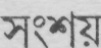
সংশয়
